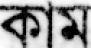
কাম
